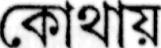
কোথায়
